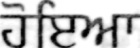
ਹੋਇਆ
